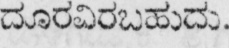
ದೂರವಿರಬಹುದು.
